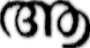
ആ
